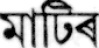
মাটিৰ
